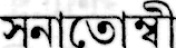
সনাতোম্বী
